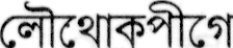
লৌথোকপীগে
